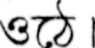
ওঠে।
